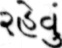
રહેવું
